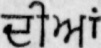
ਦੀਆਂ
